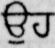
ਉਹ
